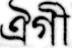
ঐগী
